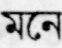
মনে
